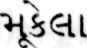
મૂકેલા
